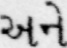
અને
